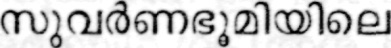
സുവര്‍ണഭൂമിയിലെ
